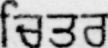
ਚਿਤਰ
